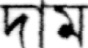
দাম
